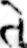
તે
